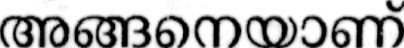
അങ്ങനെയാണ്
